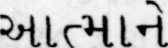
આત્માને
